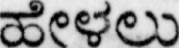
ಹೇಳಲು
